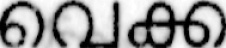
വെക്ക
